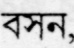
বসন,
